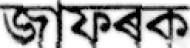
জাফৰক
